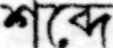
শব্দে
